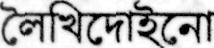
লৈখিদোইনো
